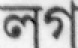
লগ
